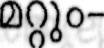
മറ്റും-
